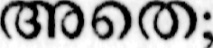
അതെ;
